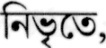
নিভৃতে,
